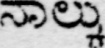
ನಾಲ್ಕು
